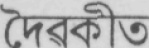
দৈৱকীত
